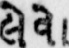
લેવો
